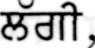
ਲੱਗੀ,
